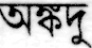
অঙ্কদু
